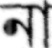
না
